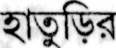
হাতুড়ির
